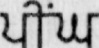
ਪੀਂਘ
